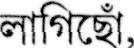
লাগিছোঁ,
